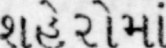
શહેરોમાં
